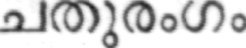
ചതുരംഗം
